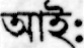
আই:
